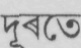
দূৰতে
